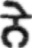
ਨੇ
